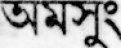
অমসুং
